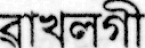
ৱাখলগী
